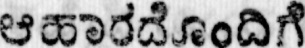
ಆಹಾರದೊಂದಿಗೆ
